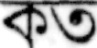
কত
